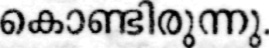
കൊണ്ടിരുന്നു.
